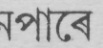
নপাৰে
